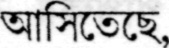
আসিতেছে,
